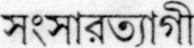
সংসারত্যাগী
